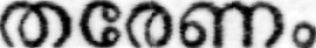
തരേണം
